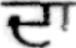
ਦਾ
